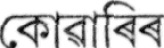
কোৱাৰিৰ
